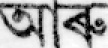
আৰু
